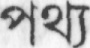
পথ্য
